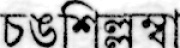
চঙশিল্লম্বা
